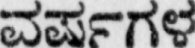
ವರ್ಷಗಳ
